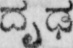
ದೃಢ
